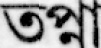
তপ্না
